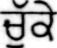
ਚੁੱਕੇ
